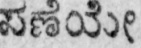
ಪಣೆಯೇ
